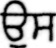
ਉਸ
